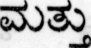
ಮತ್ತು
